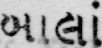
બાલાં
